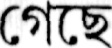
গেছে
